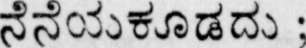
ನೆನೆಯಕೂಡದು;
